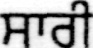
ਸਾਰੀ
